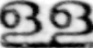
ള്ള
